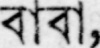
বাবা,
